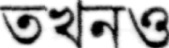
তখনও
